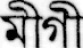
মীগী
